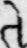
તે
